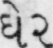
ઘેર
